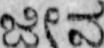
ಜೀವ
